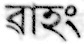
ৱাহং
